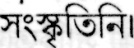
সংস্কৃতিনি।
